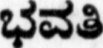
ಭವತಿ
